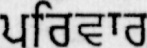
ਪਰਿਵਾਰ
